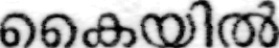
കൈയില്‍
